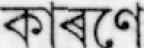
কাৰণে
